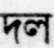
দল
